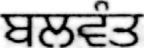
ਬਲਵੰਤ
